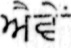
ਐਵੇਂ
